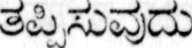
ತಪ್ಪಿಸುವುದು
